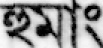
হুমাং
